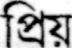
প্রিয়
